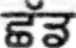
ਛੱਡ
